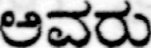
ಅವರು
